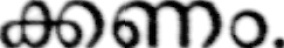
ക്കണം.
